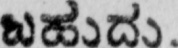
ಬಹುದು.
